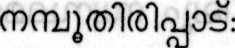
നമ്പൂതിരിപ്പാട്:
